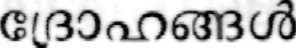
ദ്രോഹങ്ങള്‍
